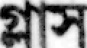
গ্লাস
